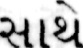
સાથે
